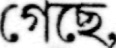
গেছে,
